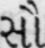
સૌ
